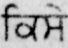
ਕਿਸੇ
